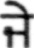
ਜੇ
